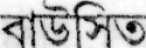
বাউসিত
